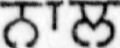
ਨਾਲ
